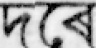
দৰে
